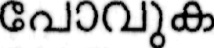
പോവുക
